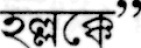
হল্লক্কে”
